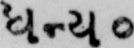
ધન્ય.
